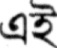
এই
